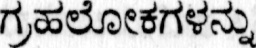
ಗ್ರಹಲೋಕಗಳನ್ನು
